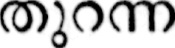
തുറന്ന
